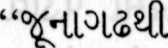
"જૂનાગઢથી
